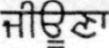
ਜੀਊਣਾ
